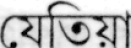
যেতিয়া
